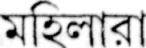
মহিলারা
